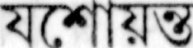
যশোয়ন্ত
